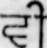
ਵੀ
